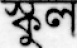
স্কুল
